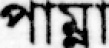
পাম্না
